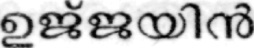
ഉജ്ജയിന്‍
